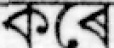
কৰে
